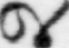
જ
